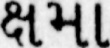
ક્ષમા
